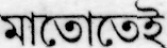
মাতোতেই
